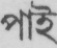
পাই
